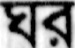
ঘর
